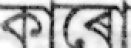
কাৰো
